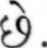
છે.
